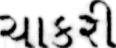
ચાકરી
